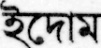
ইদোম
